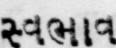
સ્વભાવ
